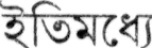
ইতিমধ্যে
